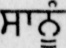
ਸਾਨੂੰ
